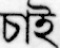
চাই
